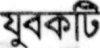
যুবকটি
